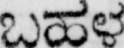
ಬಹಳ
